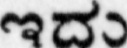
ಇದು
